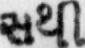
સથી
